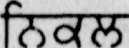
ਨਿਕਲ
